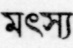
মত্স্য
